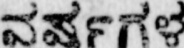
ವರ್ಷಗಳ
